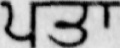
ਪਤਾ
